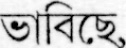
ভাবিছে,
